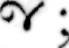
જ;
